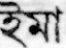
ইমা
